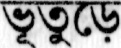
ভূতুড়ে
